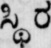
ಸ್ಥಿರ
